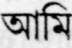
আমি
